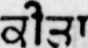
ਕੀਤਾ
